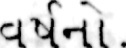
વર્ષનો.
